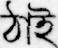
ঠাই
